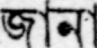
জানা
